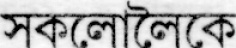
সকলোলৈকে
